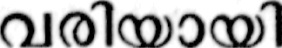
വരിയായി
